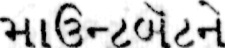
માઉન્ટબૅટને
